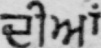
ਦੀਆਂ
